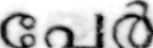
പേര്‍
